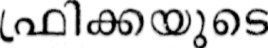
ഫ്രിക്കയുടെ
